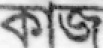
কাজ
